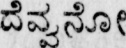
ದೆವ್ವನೋ
